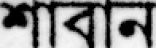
শাবান
